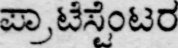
ಪ್ರಾಟೆಸ್ಟೆಂಟರ
